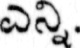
ಎನ್ನಿ.
